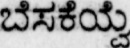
ಬೆಸಕೆಯ್ವೆ
